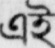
এই
